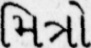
મિત્રો
